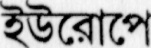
ইউরোপে
